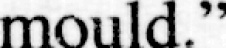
mould.”
